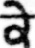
ਕੇ
